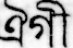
ঐগী
